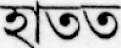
হাতত
